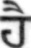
ਹੈ
